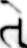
તે
